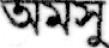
অমসু
